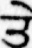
ਤੇ
